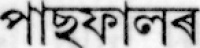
পাছফালৰ
